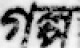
গল্প
